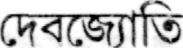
দেবজ্যোতি
